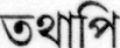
তথাপি
